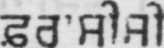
ਫ਼ਰਾਸੀਸੀ
